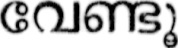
വേണ്ടൂ
